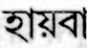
হায়বা
